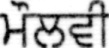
ਮੌਲਵੀ
